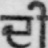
ਦੀ
